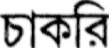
চাকরি
